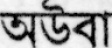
অউবা
